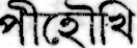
পীহৌখি
